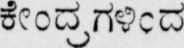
ಕೇಂದ್ರಗಳಿಂದ
